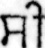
ਸੀ
